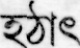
হঠাৎ
